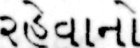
રહેવાનો
